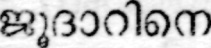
ജൂദാറിനെ
